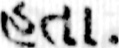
હતા.
